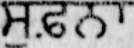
ਸੁਫ਼ਨਾ
